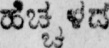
ಹೆಚ್ಚಳದ
